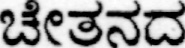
ಚೇತನದ
